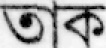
তাক
